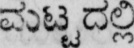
ಮಟ್ಟದಲ್ಲಿ
